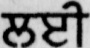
ਲਈ
